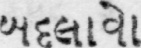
બદલાવો
